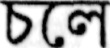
চলে
